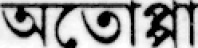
অতোপ্পা
